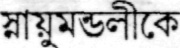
স্নায়ুমন্ডলীকে
